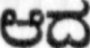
ಆದ
